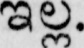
ಇಲ್ಲ.
